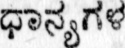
ಧಾನ್ಯಗಳ
